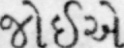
જોઈએ
